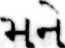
મને
